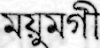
ময়ুমগী
